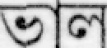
ভাল
